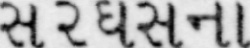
સરઘસના
